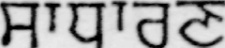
ਸਾਧਾਰਣ
